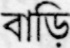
বাড়ি
